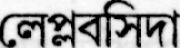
লেপ্লবসিদা
